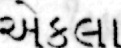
એકલા
